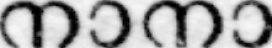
നാനാ
